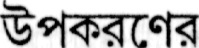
উপকরণের
